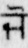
ਜੋ
